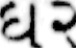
ઘર
